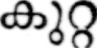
കുറ്റ
